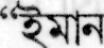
"ইমান
